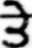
ਤੇ
